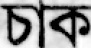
চাক
